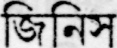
জিনিস
